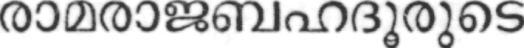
രാമരാജബഹദൂരുടെ
